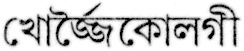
খোর্জ্জৈকোলগী
